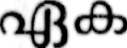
ഏക
